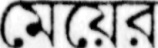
মেয়ের
